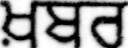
ਖ਼ਬਰ
